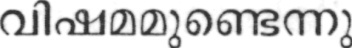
വിഷമമുണ്ടെന്നു
